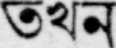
তখন
